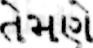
તેમણે
